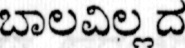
ಬಾಲವಿಲ್ಲದ
